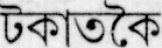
টকাতকৈ
